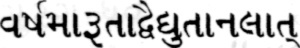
વર્ષમારૂતાદ્ધૈદ્યુતાનલાત્
